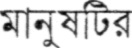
মানুষটির
